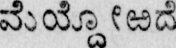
ಮೆಯ್ದೋಱದೆ
